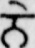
ਨੇ
